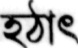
হঠাৎ
